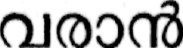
വരാന്‍
